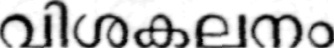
വിശകലനം
